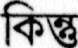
কিন্তু
